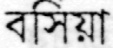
বসিয়া
